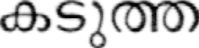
കടുത്ത
